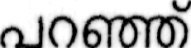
പറഞ്ഞ്
